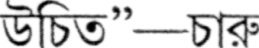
উচিত”–চারু
